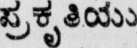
ಪ್ರಕೃತಿಯು
